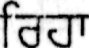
ਰਿਹਾ
